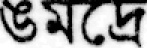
ঙমদ্রে
